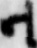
ન
